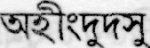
অহীংদুদসু
